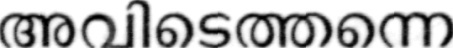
അവിടെത്തന്നെ
